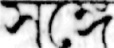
সঙ্গে
